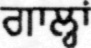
ਗਾਲ੍ਹਾਂ
